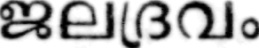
ജലദ്രവം
